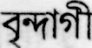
বৃন্দাগী
